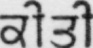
ਕੀਤੀ
